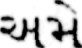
અમે
